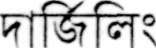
দার্জিলিং
